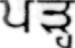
ਪੜ੍ਹ
